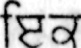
ਇਕ
